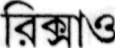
রিক্সাও
